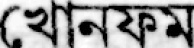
খোনফম
